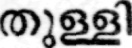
തുള്ളി
